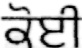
ਕੋਈ
